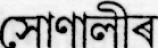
সোণালীৰ
